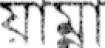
য়াম্না
